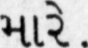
મારે.
